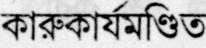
কারুকার্যমণ্ডিত
